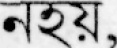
নহয়,
